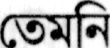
তেমনি
